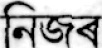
নিজৰ
